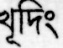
খূদিং
